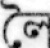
লৈ
